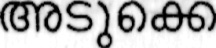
അടുക്കെ
